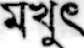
মখুৎ
